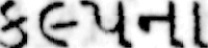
કલ્પના
